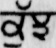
ਕੁੱਝ
